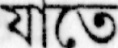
যাতে
